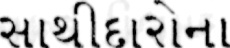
સાથીદારોના
